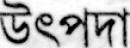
উৎপদা
